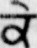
ਕੇ
